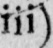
iii)
